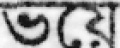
ভয়ে
